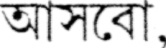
আসবো,
